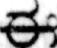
ಈ
